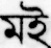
মই
